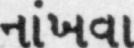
નાંખવા
